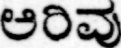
ಅರಿವು
